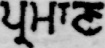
ਪ੍ਰਮਾਣ
